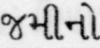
જમીનો
